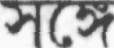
সঙ্গে
